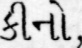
કીનો,
